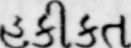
હકીકત
